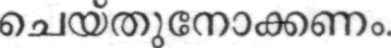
ചെയ്തുനോക്കണം.
